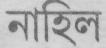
নাহিল
